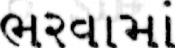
ભરવામાં
